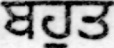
ਬਹੁਤ
